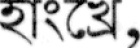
হাংখ্রে,
